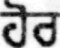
ਹੋਰ
